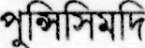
পুন্সিসিমদি
